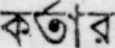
কর্তার
